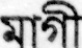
মাগী
